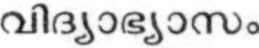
വിദ്യാഭ്യാസം
